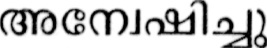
അന്വേഷിച്ചു
